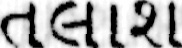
તલાશ
